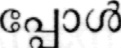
പ്പോള്‍
